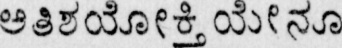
ಅತಿಶಯೋಕ್ತಿಯೇನೂ
